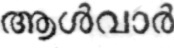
ആള്‍വാര്‍
